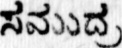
ಸಮುದ್ರ
